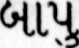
બાપુ
